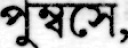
পুম্বসে,
